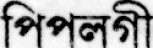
পিপলগী
